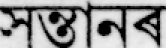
সন্তানৰ
